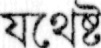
যথেষ্ট
